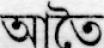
আতৈ
